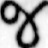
જ
